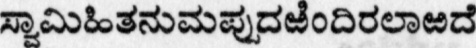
ಸ್ವಾಮಿಹಿತನುಮಪ್ಪುದಱಂದಿರಲಾಱದೆ
